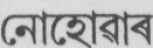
নোহোৱাৰ
